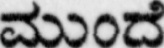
ಮುಂದೆ
